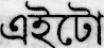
এইটো
